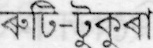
ৰুটি-টুকুৰা
